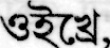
ওইখ্রে,
